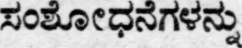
ಸಂಶೋಧನೆಗಳನ್ನು
